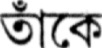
তাঁকে
